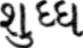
શુધ્ધ
